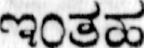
ಇಂತಹ
